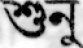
শুনু
